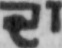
ਦਾ
